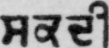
ਸਕਦੀ
